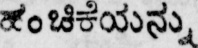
ಹಂಚಿಕೆಯನ್ನು
